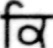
ਕਿ
